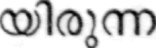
യിരുന്ന
